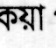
কয়া
